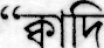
“ক্বাদি
